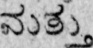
ಮತ್ತು
